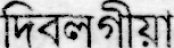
দিবলগীয়া
